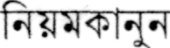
নিয়মকানুন
